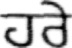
ਹਰੇ
